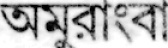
অমুরাংবা
